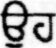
ਉਹ
